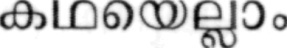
കഥയെല്ലാം
